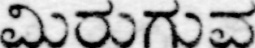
ಮಿರುಗುವ
